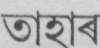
তাহাৰ
